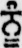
ਨੂੰ
